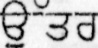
ਉੱਤਰ
